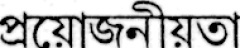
প্রয়োজনীয়তা
